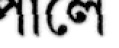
পালে
